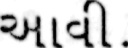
આવી.
